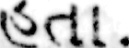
હતા.
